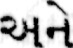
અને
